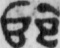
ਓਏ
